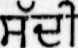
ਸੱਦੀ
